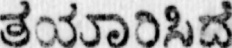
ತಯಾರಿಸಿದ
